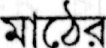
মাঠের
